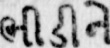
ભીડીને
